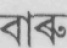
বাৰু
